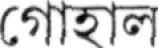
গোহাল
